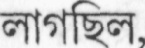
লাগছিল,
